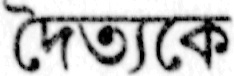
দৈত্যকে
